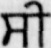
ਸੀ
